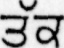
ਤੱਕ
